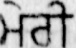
ਮੇਰੀ
